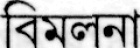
বিমলনা
